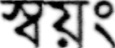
স্বয়ং
